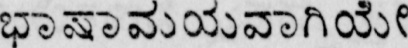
ಭಾಷಾಮಯವಾಗಿಯೇ
